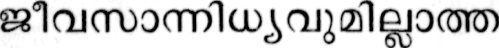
ജീവസാന്നിധ്യവുമില്ലാത്ത
